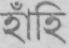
হাঁহি
